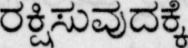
ರಕ್ಷಿಸುವುದಕ್ಕೆ
